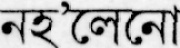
নহ'লেনো
